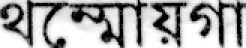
থম্মোয়গা
